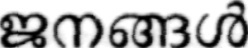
ജനങ്ങള്‍
